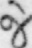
જે
